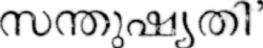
സന്തുഷ്യതി'
